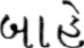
બાહે
